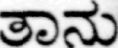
ತಾನು
